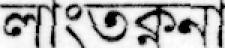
লাংতক্ননা
